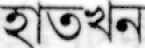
হাতখন
